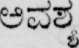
ಅವಶ್ಯ
